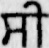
ਸੀ
